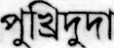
পুখ্রিদুদা
